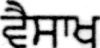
ਵੈਸਾਖ
